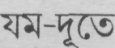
যম-দূতে
